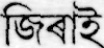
জিৰাই
